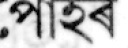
পোহৰ
